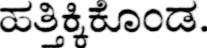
ಹತ್ತಿಕ್ಕಿಕೊಂಡ.
